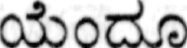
ಯೆಂದೂ
